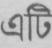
এটি
